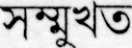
সন্মুখত
